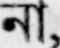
না,
